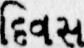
દિવસ
